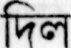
দিল
